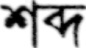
শব্দ
